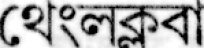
থেংলক্লবা
